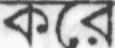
করে
